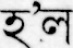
হ'ল
